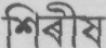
শিৰীষ
